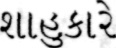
શાહુકારે
